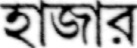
হাজার
